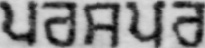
ਪਰਸਪਰ
